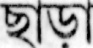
ছাড়া
